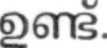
ഉണ്ട്.
